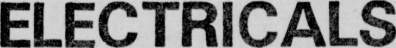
ELECTRICALS
